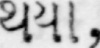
થયા,
